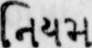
નિયમ
